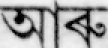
আৰু
